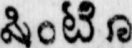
ಷಿಂಟೊ
